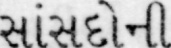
સાંસદોની
